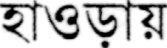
হাওড়ায়
